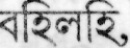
বহিলহি,
